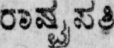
ರಾಷ್ಟ್ರಪತಿ
